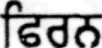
ਫਿਰਨ
